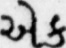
એક
